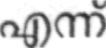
എന്ന്
